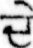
ਦੇ
